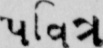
પવિત્ર
